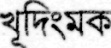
খূদিংমক
